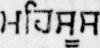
ਮਹਿਸੂਸ
